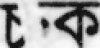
চক
